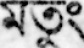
মতুং
